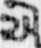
એ
